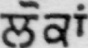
ਲੋਕਾਂ
